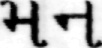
મન
